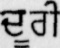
ਦੂਰੀ
